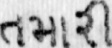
તમારી
